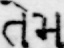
તેમ
